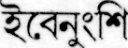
ইবেনুংশি
